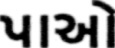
પાઓ
